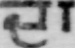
ਦਾ
